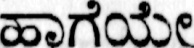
ಹಾಗೆಯೇ
